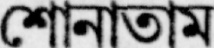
শোনাতাম
